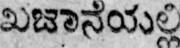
ಖಜಾನೆಯಲ್ಲಿ
